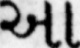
આ
